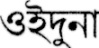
ওইদুনা
